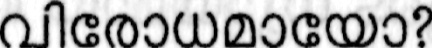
വിരോധമായോ?
